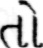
તો
